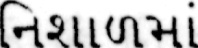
નિશાળમાં
